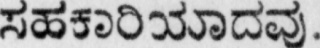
ಸಹಕಾರಿಯಾದವು.
